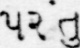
પરંતુ
